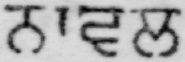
ਨਾਵਲ
